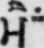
ਮੈਂ
